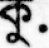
কু.
